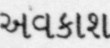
અવકાશ
